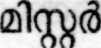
മിസ്റ്റര്‍
